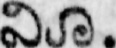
ಮೀ.
